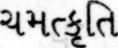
ચમત્કૃતિ
